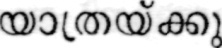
യാത്രയ്ക്കു
